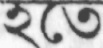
হতে
